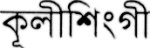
কূলীশিংগী
